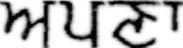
ਅਪਣਾ
